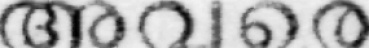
അവരെ
